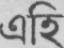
এহি
